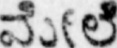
ಮೇಲೆ
